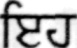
ਇਹ
